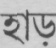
হাড়
